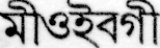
মীওইবগী
